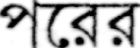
পরের
